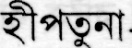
হীপতুনা
